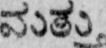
ಮತ್ತು
